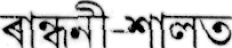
ৰান্ধনী-শালত
